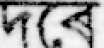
দৰে
